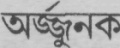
অৰ্জ্জুনক
